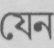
যেন
